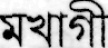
মখাগী
